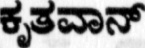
ಕೃತವಾನ್
